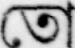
তো
